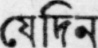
যেদিন
